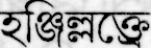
হঞ্জিল্লক্ত্রে
